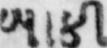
બાકી
